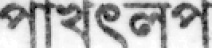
পাখৎলপ
